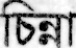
চিন্না
